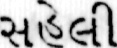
સહેલી
